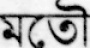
মতৌ
